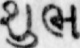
શુભ
